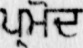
ਪ੍ਰਮੋਦ
